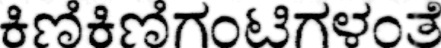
ಕಿಣಿಕಿಣಿಗಂಟಿಗಳಂತೆ
